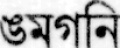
ঙমগনি
